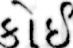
કોઇ
